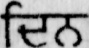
ਦਿਨ
